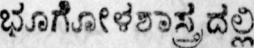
ಭೂಗೋಳಶಾಸ್ತ್ರದಲ್ಲಿ
